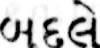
બદલે
